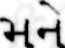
મને
